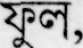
ফুল,
